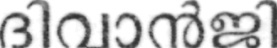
ദിവാന്‍ജി
